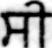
ਸੀ
